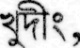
খুদীং,
